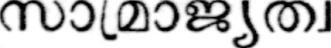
സാമ്രാജ്യത്വ
